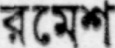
রমেশ
